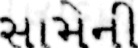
સામેની
